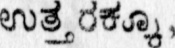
ಉತ್ತರಕ್ಕೂ,
